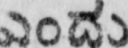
ಎಂದು
